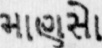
માણસો
